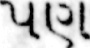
પણ
